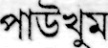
পাউখুম
